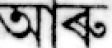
আৰু
